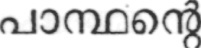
പാന്ഥന്റെ
